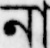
না
